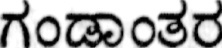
ಗಂಡಾಂತರ
